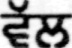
ਵੱਲ
